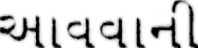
આવવાની
